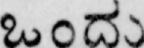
ಒಂದು
